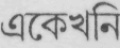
একেখনি
